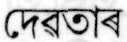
দেৱতাৰ
